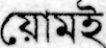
য়োমই
